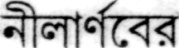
নীলার্ণবের
